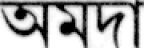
অমদা
